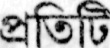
প্রতিটি
